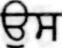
ਉਸ
